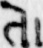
તો
